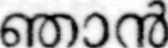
ഞാന്‍
